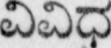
ವಿವಿಧ
